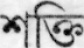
শক্তি
